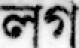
লগ
